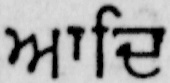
ਆਦਿ
